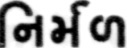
નિર્મળ
